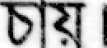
চায়।
